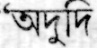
“অদুদি
